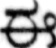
ಈ
